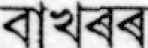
বাখৰৰ
